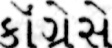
કૉંગ્રેસે
